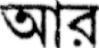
আর
